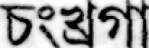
চংখ্রগা
